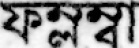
ফম্লম্বা
